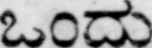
ಒಂದು
